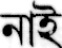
নাই
